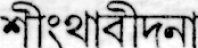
শীংথাবীদনা
